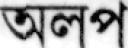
অলপ
